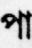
পা
